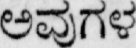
ಅವುಗಳ
